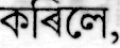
কৰিলে,
